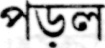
পড়ল
